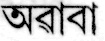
অৱাবা
